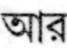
আর
